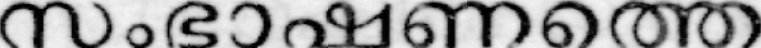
സംഭാഷണത്തെ
